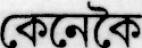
কেনেকৈ
